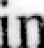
in
